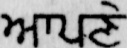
ਆਪਣੇ
